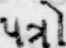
પત્રો
